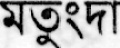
মতুংদা
